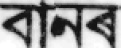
বানৰ
